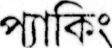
প্যাকিং
